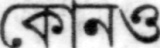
কোনও
